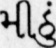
મીઠું
